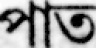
পাত
